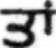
ਤਾਂ
